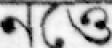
নত্তে
